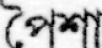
পৈশা
